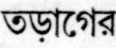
তড়াগের
